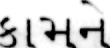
કામને
